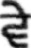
ਵੇ
